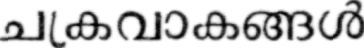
ചക്രവാകങ്ങള്‍
